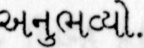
અનુભવ્યો.
